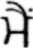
ਮੈਂ
